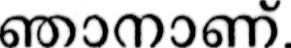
ഞാനാണ്.
